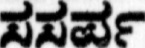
ಸಸರ್ಪ
